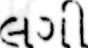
લગી
